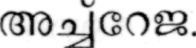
അച്ച്റേജ.
